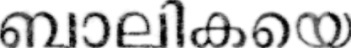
ബാലികയെ
